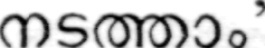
നടത്താം’
